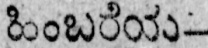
ಹಿಂಬರೆಯ-
